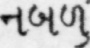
નબળું
